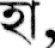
হা,
